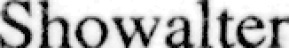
Showalter
